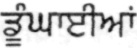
ਡੂੰਘਾਈਆਂ
